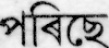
পৰিছে
